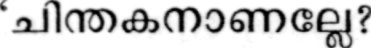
‘ചിന്തകനാണല്ലേ?
